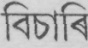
বিচাৰি
